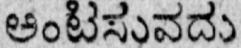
ಅಂಟಿಸುವದು
